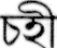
চহী
